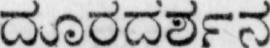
ದೂರದರ್ಶನ
